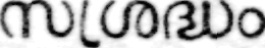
സശ്രദ്ധം
